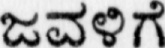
ಜವಳಿಗೆ
